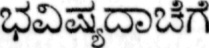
ಭವಿಷ್ಯದಾಚೆಗೆ
